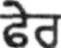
ਫੇਰ
